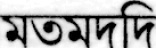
মতমদদি
